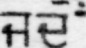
ਜਦੋਂ
